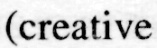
(creative
